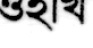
ওইখি
